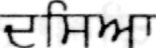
ਦਸਿਆ
